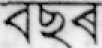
বছৰ
